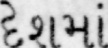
દેશમાં
